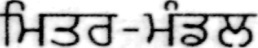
ਮਿਤਰ-ਮੰਡਲ
